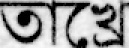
তাখ্রে
